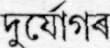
দুর্যোগৰ
